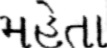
મહેતા
